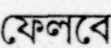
ফেলবে
